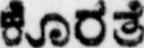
ಕೊರತೆ
